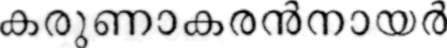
കരുണാകരന്‍നായര്‍
